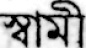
স্বামী
